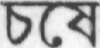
চষে
